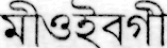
মীওইবগী
